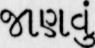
જાણવું
